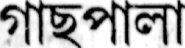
গাছপালা
